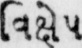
વિક્ષેપ
